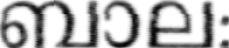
ബാല:
